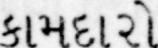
કામદારો
